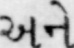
અને
